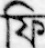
ফি
